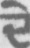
ਦੇ
